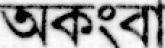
অকংবা
